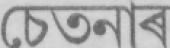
চেতনাৰ
